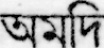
অমদি
